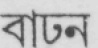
বাঢ়ন
